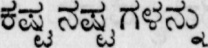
ಕಷ್ಟನಷ್ಟಗಳನ್ನು
